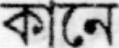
কানে
